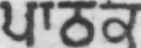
ਪਾਠਕ
